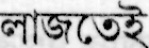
লাজতেই
